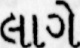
લાગે
